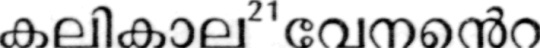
കലികാല21വേനന്റെ
